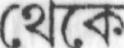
থেকে
